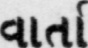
વાર્તા
